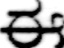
ಈ
